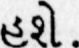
હશે.
